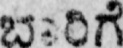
ಬಾರಿಗೆ
